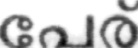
പേര്
